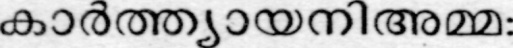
കാര്‍ത്ത്യായനിഅമ്മ:
